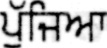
ਪੁੱਜਿਆ
